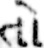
તો
